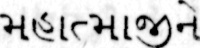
મહાત્માજીને
